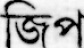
জিপ
